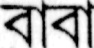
বাবা
